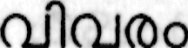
വിവരം
